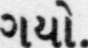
ગયો.
